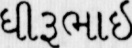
ધીરૂભાઈ
